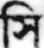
সি
